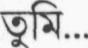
তুমি...
